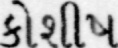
કોશીષ
